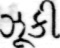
ઝૂકી
